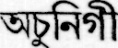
অচুনিগী
